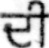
ਦੀ
